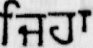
ਜਿਹਾ
